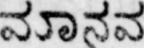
ಮಾನವ
